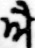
ਐ
